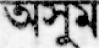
অসুম
